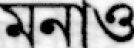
মনাও
